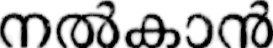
നല്‍കാന്‍
